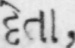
દેતા,
